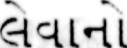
લેવાનો
